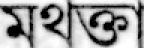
মথক্তা
